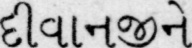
દીવાનજીને
